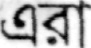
এরা
